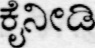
ಕೈನೀಡಿ
